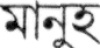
মানুহ
